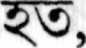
হত,
